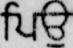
ਪਿਉ
